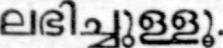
ലഭിച്ചുള്ളൂ.
